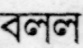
বলল
